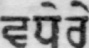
ਵਧੇਰੇ
